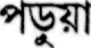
পড়ুয়া
